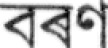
বৰণ
